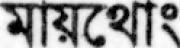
মায়থোং
